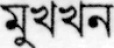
মুখখন
